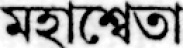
মহাশ্বেতা
